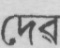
দেৱ
